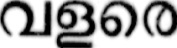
വളരെ
